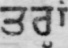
ਤਰ੍ਹਾਂ
